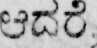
ಆದರೆ.
